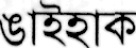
ঙাইহাক
